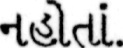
નહોતાં.
